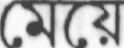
মেয়ে
